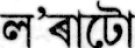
ল'ৰাটো
